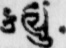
કહ્યું.
